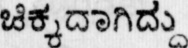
ಚಿಕ್ಕದಾಗಿದ್ದು
